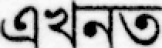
এখনত
